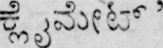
ಕ್ಲೈಮೇಟ್’
